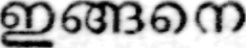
ഇങ്ങനെ
